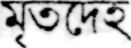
মৃতদেহ
